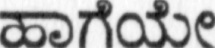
ಹಾಗೆಯೇ
